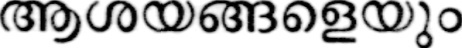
ആശയങ്ങളെയും
